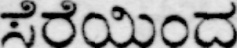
ಸೆರೆಯಿಂದ
